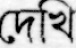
দেখি
